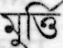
মুর্ত্তি
